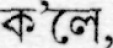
ক'লে,
